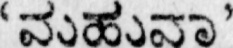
‘ಮಹುವಾ’
